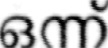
ഒന്ന്
